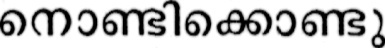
നൊണ്ടിക്കൊണ്ടു
